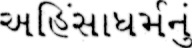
અહિંસાધર્મનું
